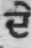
ਦੇ
